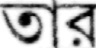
তার
